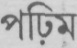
পঢ়িম
